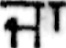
ਜਾ
